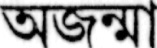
অজন্মা
